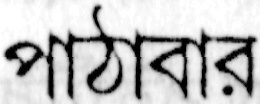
পাঠাবার
